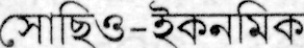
সোছিও-ইকনমিক
